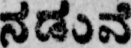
ನಡುವೆ
